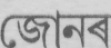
জোনৰ
